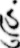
હું
